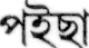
পইছা
